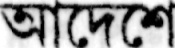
আদেশে
